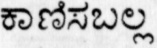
ಕಾಣಿಸಬಲ್ಲ
